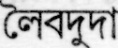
লৈবদুদা
